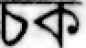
চক
